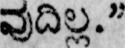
ವುದಿಲ್ಲ.”
